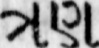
ત્રણ
